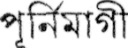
পূর্নিমাগী
